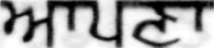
ਆਪਣਾ
